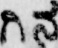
ಗಿನ
